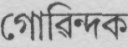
গোৱিন্দক
